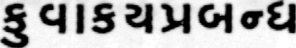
કુવાક્યપ્રબન્ધ
